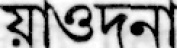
য়াওদনা
